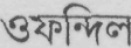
ওফন্দিল
